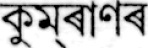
কুম্‌ৰাণৰ
